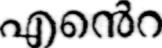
എന്റെ
